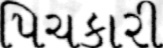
પિચકારી
